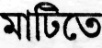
মাটিতে
